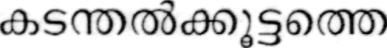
കടന്തല്‍ക്കൂട്ടത്തെ
